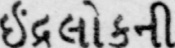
ઇંદ્રલોકની
